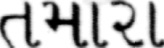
તમારા
